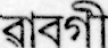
ৱাবগী
